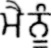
ਮੈਨੂੰ
